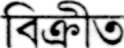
বিক্রীত
